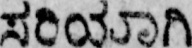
ಸರಿಯಾಗಿ
